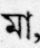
মা,
